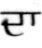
ਦਾ
